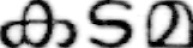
കടമ
